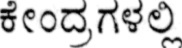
ಕೇಂದ್ರಗಳಲ್ಲಿ
